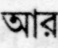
আর
